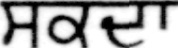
ਸਕਦਾ
